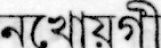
নখোয়গী
